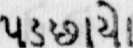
પડછાયો
